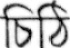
চিঠি
